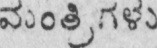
ಮಂತ್ರಿಗಳು
